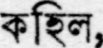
কহিল,
